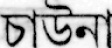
চাউনা
